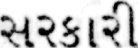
સરકારી
